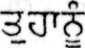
ਤੁਹਾਨੂੰ
